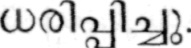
ധരിപ്പിച്ചു.
